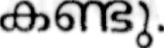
കണ്ടു.
